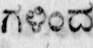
ಗಳಿಂದ
